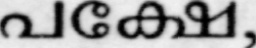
പക്ഷേ,
